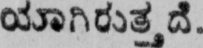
ಯಾಗಿರುತ್ತದೆ.
